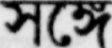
সঙ্গে
